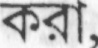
করা,
